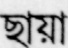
ছায়া
